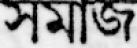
সমাজ
